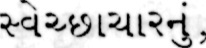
સ્વેચ્છાચારનું,
